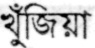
খুঁজিয়া
